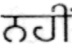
ਨਹੀਂ
